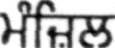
ਮੰਜ਼ਿਲ
